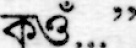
কওঁ..."
